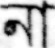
না
